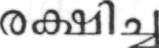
രക്ഷിച്ച
